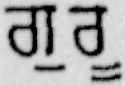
ਗੁਰੂ
